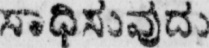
ಸಾಧಿಸುವುದು
